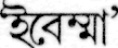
‘ইবেম্মা’
